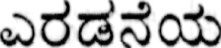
ಎರಡನೆಯ
